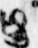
છું
